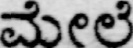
ಮೇಲೆ
